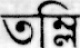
তম্লি
